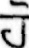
ਹੋ
